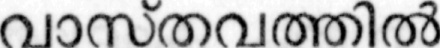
വാസ്തവത്തില്‍
